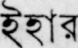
ইহার
